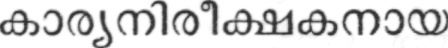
കാര്യനിരീക്ഷകനായ
